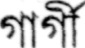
গার্গী
